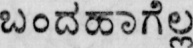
ಬಂದಹಾಗೆಲ್ಲ
